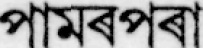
পামৰপৰা
